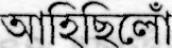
আহিছিলোঁ
